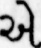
એ
